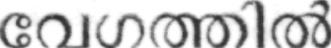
വേഗത്തില്‍
